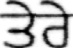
ਤੇਰੇ
